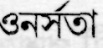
ওনর্সতা
